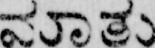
ಮಾತು
